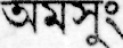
অমসুং
